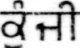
ਕੁੰਜੀ
